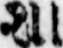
શા
